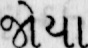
જોયા
